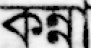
কন্না
